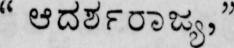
“ಆದರ್ಶರಾಜ್ಯ”
